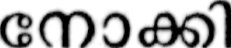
നോക്കി
